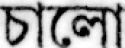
চালো
